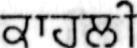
ਕਾਹਲੀ
